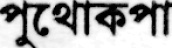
পুথোকপা
